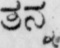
ತನ್ನ
